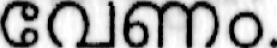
വേണം.
